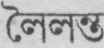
লৈলন্ত
